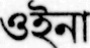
ওইনা
